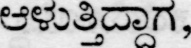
ಆಳುತ್ತಿದ್ದಾಗ,
